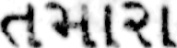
તમારા
